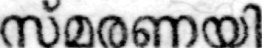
സ്മരണയി
